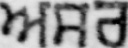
ਅਸਰ
